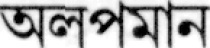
অলপমান
